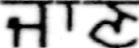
ਜਾਣ
